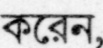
করেন,
